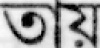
তায়
